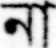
না
